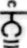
ਨੂੰ
